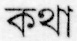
কথা
